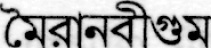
মৈরানবীগুম
